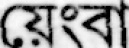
য়েংবা
